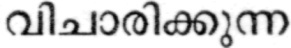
വിചാരിക്കുന്ന
